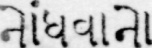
નોંધવાનો
